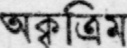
অকৃত্রিম
